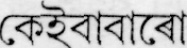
কেইবাবাৰো
